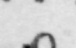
એમ
